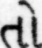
તો
